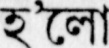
হ'লো
